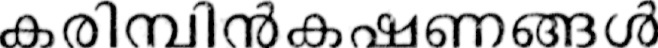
കരിമ്പിന്‍കഷണങ്ങള്‍
